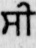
ਸੀ
